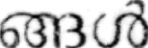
ങ്ങള്‍
